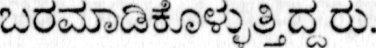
ಬರಮಾಡಿಕೊಳ್ಳುತ್ತಿದ್ದರು.
